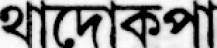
থাদোকপা
